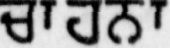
ਚਾਹਨਾ
